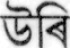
উৰি
